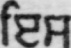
ਇਸ
